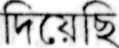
দিয়েছি
